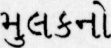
મુલકનો
